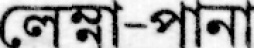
লেম্না-পানা
